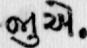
જુએ.
